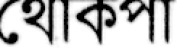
থোকপা
